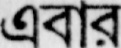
এবার
